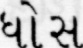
ધોસ
